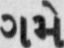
ગમે
